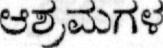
ಆಶ್ರಮಗಳ
